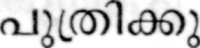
പുത്രിക്കു
